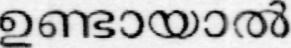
ഉണ്ടായാല്‍
